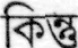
কিন্তু
